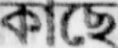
কাছে
